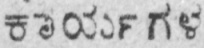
ಕಾರ್ಯಗಳ
